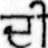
ਦੀ
